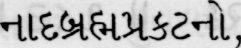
નાદબ્રહ્મપ્રકટનો,
